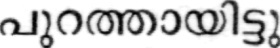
പുറത്തായിട്ടു
